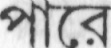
পারে
